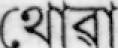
থোৱা
